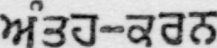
ਅੰਤਹ-ਕਰਨ
